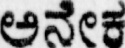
ಅನೇಕ
